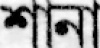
শানা
